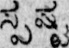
ಸ್ಪಷ್ಟ
